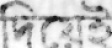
দিয়েই
